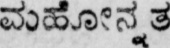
ಮಹೋನ್ನತ
